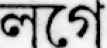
লগে
